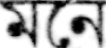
মনে
